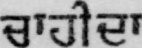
ਚਾਹੀਦਾ
